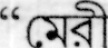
“মেরী
